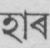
হাৰ
